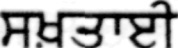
ਸਖ਼ਤਾਈ
